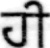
ਹੀ
